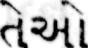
તેઓ
